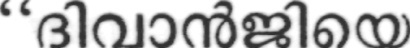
"ദിവാന്‍ജിയെ
